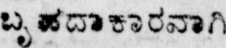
ಬೃಹದಾಕಾರವಾಗಿ
